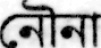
নৌনা
